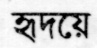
হৃদয়ে
